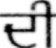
ਦੀ
